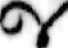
જ
